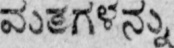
ಮತಗಳನ್ನು
